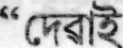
"দেৱাই
